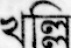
খল্লি
